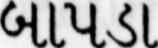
બાપડા
